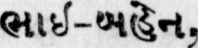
ભાઈ-બેહન,
